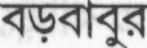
বড়বাবুর
